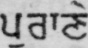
ਪੁਰਾਣੇ
